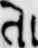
તો
